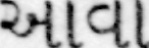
આવા
